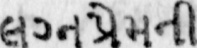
લગ્નપ્રેમની
